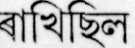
ৰাখিছিল
